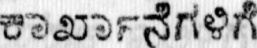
ಕಾರ್ಖಾನೆಗಳಿಗೆ
